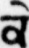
ਕੇ
